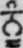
ਨੂੰ
